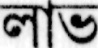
লাভ
